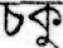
চকু
